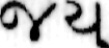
જય
